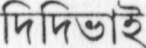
দিদিভাই
